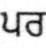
ਪਰ
